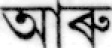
আৰু
